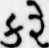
કરે
